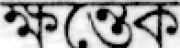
ক্ষন্তেক
